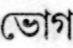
ভোগ
